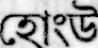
হোংউ
